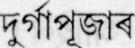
দুর্গাপূজাৰ
